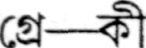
গ্রে–কী
